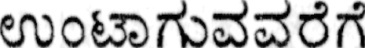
ಉಂಟಾಗುವವರೆಗೆ
